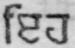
ਇਹ
